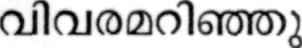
വിവരമറിഞ്ഞു
